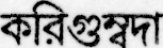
করিগুম্বদা
